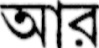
আর
